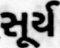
સૂર્ય
